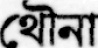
থৌনা
